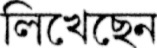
লিখেছেন
